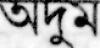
অদুম
